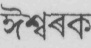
ঈশ্বৰক
